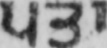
ਪਤਾ
